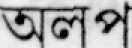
অলপ
